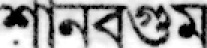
শানবগুম
